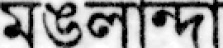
মঙলান্দা
